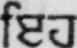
ਇਹ
